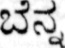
ಬೆನ್ನ
